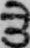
ਤੇ
